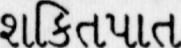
શક્તિપાત
